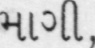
માગી,
